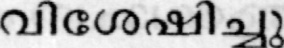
വിശേഷിച്ചു
